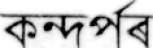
কন্দর্পৰ
